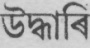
উদ্ধাৰি
